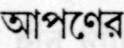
আপণের
